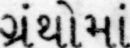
ગ્રંથોમાં
